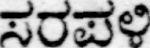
ಸರಪಳಿ
